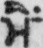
ਮੈਂ
